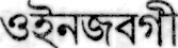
ওইনজবগী
